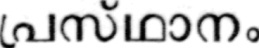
പ്രസ്ഥാനം
